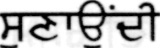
ਸੁਣਾਉਂਦੀ
